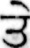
ਤੇ
